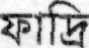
ফাদ্রি
